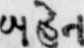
બહેન
